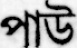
পাউ
